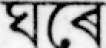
ঘৰে
